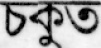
চকুত
